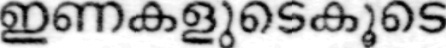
ഇണകളുടെകൂടെ
